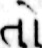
તો
